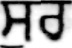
ਸੁਰ
